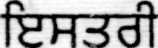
ਇਸਤਰੀ
